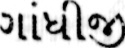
ગાંધીજી
